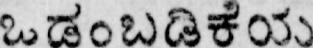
ಒಡಂಬಡಿಕೆಯ
